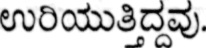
ಉರಿಯುತ್ತಿದ್ದವು.
